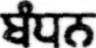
ਬੰਧਨ
